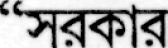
“সরকার
